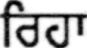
ਰਿਹਾ
